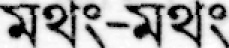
মথং-মথং
